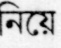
নিয়ে
